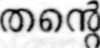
തന്റെ
